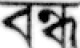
বন্ধ
